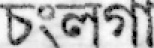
চংলগা
